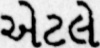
એટલે
